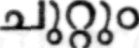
ചുറ്റും
